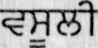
ਵਸੂਲੀ
